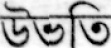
উভতি
